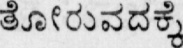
ತೋರುವದಕ್ಕೆ
